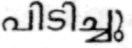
പിടിച്ചു
